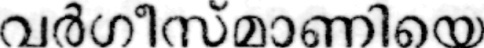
വര്‍ഗീസ്മാണിയെ
